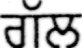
ਗੱਲ
